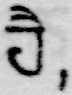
ਹੈ,
